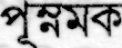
পূম্নমক
